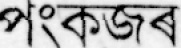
পংকজৰ
